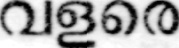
വളരെ
